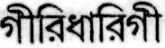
গীরিধারিগী
